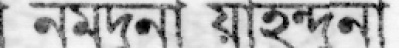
পঙলাঙ-লাঙলগা
